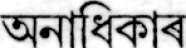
অনাধিকাৰ
